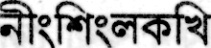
নীংশিংলকখি
